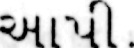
આપી.
